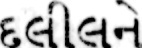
દલીલને
